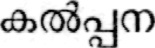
കല്‍പ്പന
